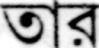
তার
